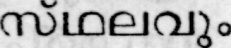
സ്ഥലവും
